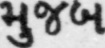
મુજબ
